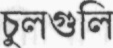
চুলগুলি
